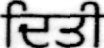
ਦਿਤੀ
